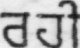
ਰਹੀ
